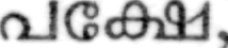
പക്ഷേ,
